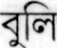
বুলি
